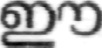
ഈ
